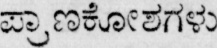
ಪ್ರಾಣಕೋಶಗಳು
